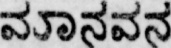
ಮಾನವನ
